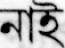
নাই
